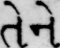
તેને
